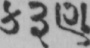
કરૂણ
